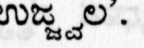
‘ಉಜ್ಜ್ವಲ’.
